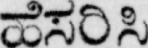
ಹೆಸರಿಸಿ
